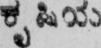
ಕೃಷಿಯ
